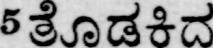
5ತೊಡಕಿದ
